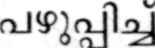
പഴുപ്പിച്ച്
